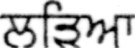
ਲੜਿਆ
